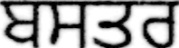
ਬਸਤਰ
